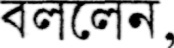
বললেন,
